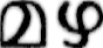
മഴ
